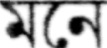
মনে
